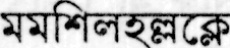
মমশিলহল্লক্লে
